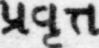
પ્રવૃત્ત
